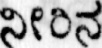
ನೀರಿನ
